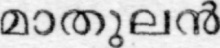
മാതുലന്‍
